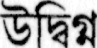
উদ্বিগ্ন
